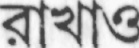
রাখাও
